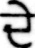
ਦੇ
